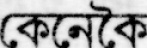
কেনেকৈ
